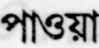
পাওয়া
